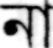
না
